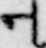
ન
